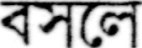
বসলে
